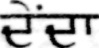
ਦੇਂਦਾ
